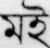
মই
